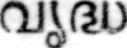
വൃദ്ധ
